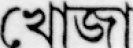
খোজা
